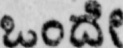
ಒಂದೇ
